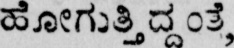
ಹೋಗುತ್ತಿದ್ದಂತೆ,
